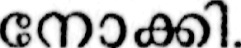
നോക്കി.
